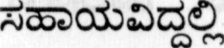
ಸಹಾಯವಿದ್ದಲ್ಲಿ
